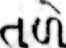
તળે
